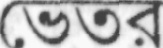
ভেতর
